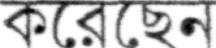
করেছেন
